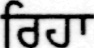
ਰਿਹਾ
